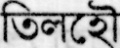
তিলহৌ
